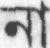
না
